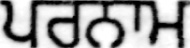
ਪਰਨਾਮ
